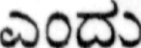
ಎಂದು
